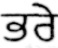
ਭਰੇ
